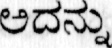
ಅದನ್ನು
